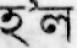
হ'ল
